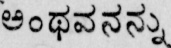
ಅಂಥವನನ್ನು
